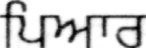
ਪਿਆਰ
